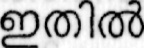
ഇതില്‍
